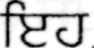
ਇਹ
